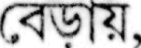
বেড়ায়,
